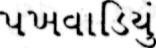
પખવાડિયું
